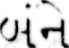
બંને
